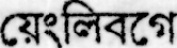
য়েংলিবগে
